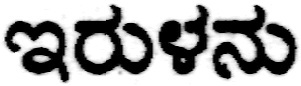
ಇರುಳನು
